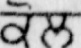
ਕੋਲ
